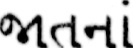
જાતનાં
